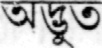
অদ্ভুত
